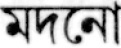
মদনো
